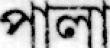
পালা
